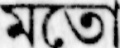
মতো
